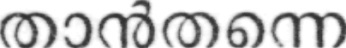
താന്‍തന്നെ
